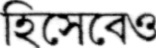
হিসেবেও
